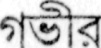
গভীর
